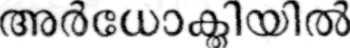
അര്‍ധോക്തിയില്‍
